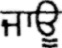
ਜਾਊ
